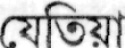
যেতিয়া
